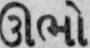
ઊભો
